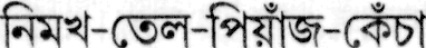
নিমখ-তেল-পিয়াঁজ-কেঁচা
